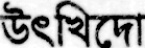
উৎখিদো
